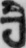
ਹੈ
